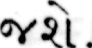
જશે.
